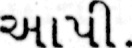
આપી.
